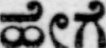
ಹೇಗೆ
